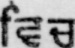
ਵਿਚ
